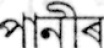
পানীৰ
